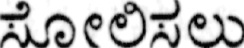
ಸೋಲಿಸಲು
